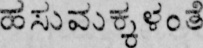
ಹಸುಮಕ್ಕಳಂತೆ
